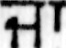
ਜਾ
